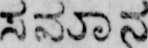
ಸಮಾನ
